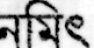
নমিৎ
